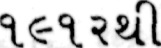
૧૯૧૨થી
